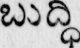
ಬುದ್ಧಿ
